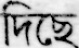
দিছে
